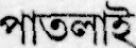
পাতলাই
